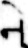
ને
